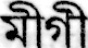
মীগী
